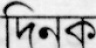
দিনক
